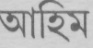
আহিম
